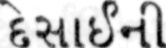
દેસાઈની
